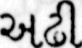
અઢી
